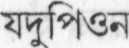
যদুপিওন
